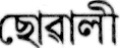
ছোৱালী
